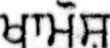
ਖਾਮੋਸ਼
